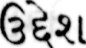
ઉદ્દેશ
